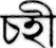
চহী
